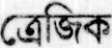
ত্রেজিক
